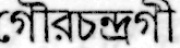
গৌরচন্দ্রগী
